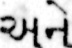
અને
